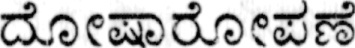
ದೋಷಾರೋಪಣೆ
